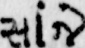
સાંજે
